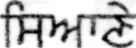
ਸਿਆਣੇ
